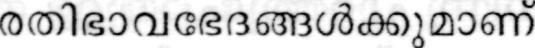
രതിഭാവഭേദങ്ങള്‍ക്കുമാണ്
